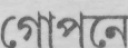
গোপনে
